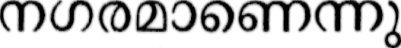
നഗരമാണെന്നു
